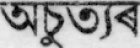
অচুত্যৰ
